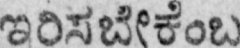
ಇರಿಸಬೇಕೆಂಬ
